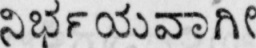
ನಿರ್ಭಯವಾಗೀ
